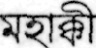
মহাক্কী
